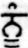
ਨੂੰ
